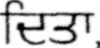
ਦਿਤਾ,
